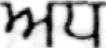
ਅਧ
